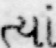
ત્યાં
